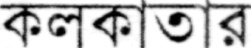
কলকাতার
